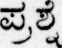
ಪ್ರಶ್ನೆ
